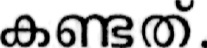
കണ്ടത്.
